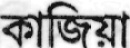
কাজিয়া
